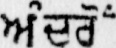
ਅੰਦਰੋਂ
